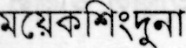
ময়েকশিংদুনা
